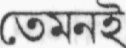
তেমনই
